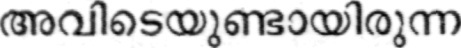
അവിടെയുണ്ടായിരുന്ന
